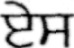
ਏਸ
